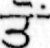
ਤੋਂ
